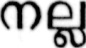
നല്ല
